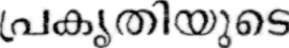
പ്രകൃതിയുടെ
